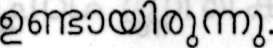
ഉണ്ടായിരുന്നു.
